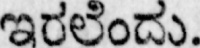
ಇರಲೆಂದು.
